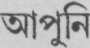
আপুনি
